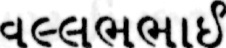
વલ્લભભાઈ
